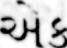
એક
